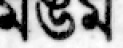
মঙম
